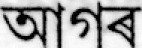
আগৰ
